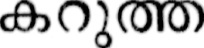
കറുത്ത
